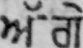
ਅੱਗੇ
